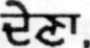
ਦੇਣਾ,
